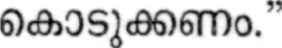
കൊടുക്കണം.”
